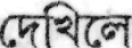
দেখিলে
